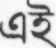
এই
